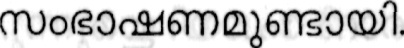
സംഭാഷണമുണ്ടായി.
